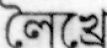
লৈখ্রে
